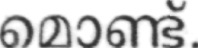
മൊണ്ട്.
